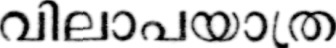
വിലാപയാത്ര
